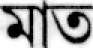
মাত
